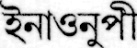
ইনাওনুপী
